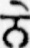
ਨੇ
